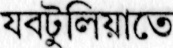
যবটুলিয়াতে
